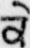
ਕੇ
